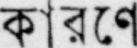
কারণে
